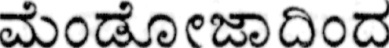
ಮೆಂಡೋಜಾದಿಂದ
